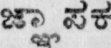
ಜ್ಞಾಪಕ
